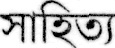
সাহিত্য
